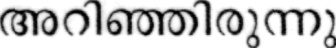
അറിഞ്ഞിരുന്നു
